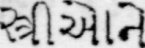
સ્ત્રીઓને
